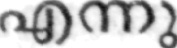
എന്നു
